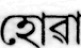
হোৱা
